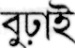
বুঢ়াই
